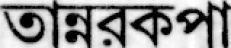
তান্নরকপা
